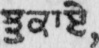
ਝੁਕਾਏ,
